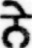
ਨੇ
